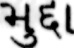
મુદ્દા
